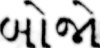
બોજો
